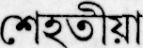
শেহতীয়া
